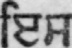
ਇਸ
